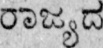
ರಾಜ್ಯದ
